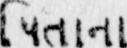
પિતાના
